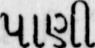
પાણી
